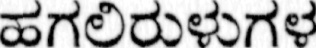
ಹಗಲಿರುಳುಗಳ
